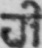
ਹੀ
